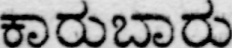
ಕಾರುಬಾರು
